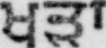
ਖੜਾ
